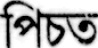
পিচত
